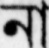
না
